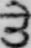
ਤੇ
